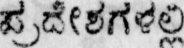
ಪ್ರದೇಶಗಳಲ್ಲಿ
